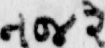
નજરે
